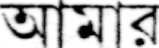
আমার
